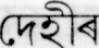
দেহীৰ
